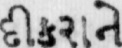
દીકરાને
